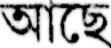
আছে
